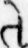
તે
